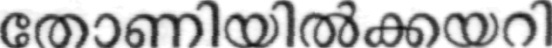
തോണിയില്‍ക്കയറി
